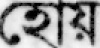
হোয়
